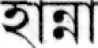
হান্না
